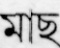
মাছ
